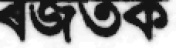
ৰজতক
